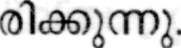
രിക്കുന്നു.
